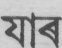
যাৰ
